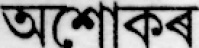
অশোকৰ
